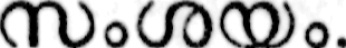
സംശയം.
